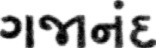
ગજાનંદ
